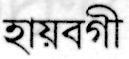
হায়বগী
